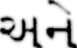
અને
